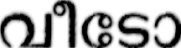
വീടോ
